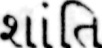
શાંતિ
